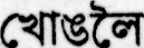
খোঙলৈ
